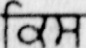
ਕਿਸ
